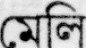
মেলি
